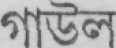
গাউল
